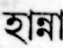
হান্না
